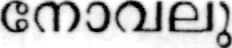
നോവലു
